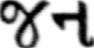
જન
